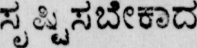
ಸೃಷ್ಟಿಸಬೇಕಾದ
